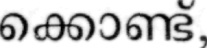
ക്കൊണ്ട്,
